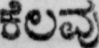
ಕೆಲವು
